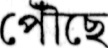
পৌঁছে
